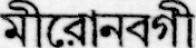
মীরোনবগী
